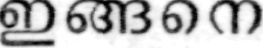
ഇങ്ങനെ
